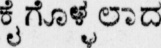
ಕೈಗೊಳ್ಳಲಾದ
